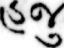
હજુ
